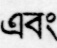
এবং
